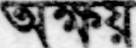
অক্ষয়
